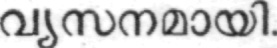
വ്യസനമായി.
